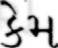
કેમ
